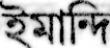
ইমান্দি
